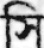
সি
